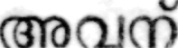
അവന്
